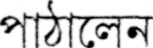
পাঠালেন
